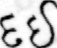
દઈ
